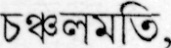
চঞ্চলমতি,
